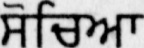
ਸੋਚਿਆ
